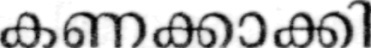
കണക്കാക്കി
